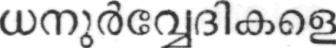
ധനുര്‍വ്വേദികളെ
